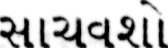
સાચવશો
